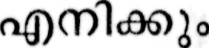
എനിക്കും
